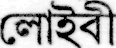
লোইবী
